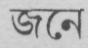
জনে
